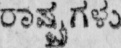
ರಾಷ್ಟ್ರಗಳು
